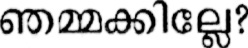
ഞമ്മക്കില്ലേ?
